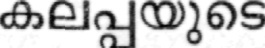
കലപ്പയുടെ
